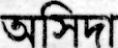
অসিদা
